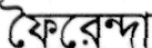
ফৈরেন্দা
